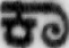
ಕಾ
